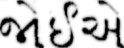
જોઈએ
